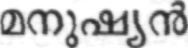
മനുഷ്യന്‍
